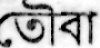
তৌবা
